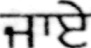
ਜਾਏ
